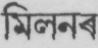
মিলনৰ
